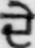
ਦੇ
